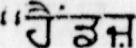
''ਹੈਂਡਜ਼
